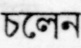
চলেন
